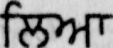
ਲਿਆ
